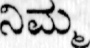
ನಿಮ್ಮ
